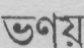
ভণয়
